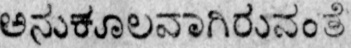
ಅನುಕೂಲವಾಗಿರುವಂತೆ
